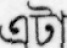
এটা
